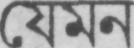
যেমন
